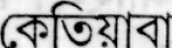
কেতিয়াবা
